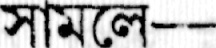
সামলে—
